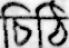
চিঠি
